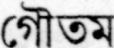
গৌতম
